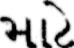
માટે
